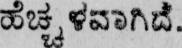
ಹೆಚ್ಚಳವಾಗಿದೆ.
